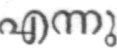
എന്നു
